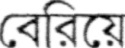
বেরিয়ে
